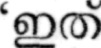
'ഇത്
